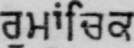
ਰੁਮਾਂਚਿਕ
